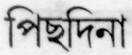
পিছদিনা
